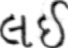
લઈ
